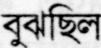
বুঝছিল
